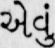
એવું
